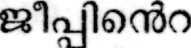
ജീപ്പിന്റെ
